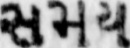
સમય
